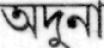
অদুনা
